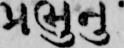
પ્રભુનું
